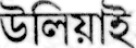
উলিয়াই
